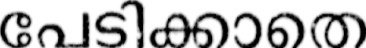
പേടിക്കാതെ
